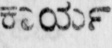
ಕಾರ್ಯ
